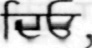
ਦਿਓ,
